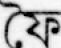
ফৈ
